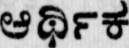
ಆರ್ಥಿಕ
